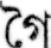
গৈ
